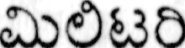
ಮಿಲಿಟರಿ
